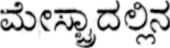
ಮೇಸ್ಟ್ರಾದಲ್ಲಿನ
